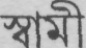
স্বামী
